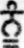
ਨੂੰ
